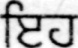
ਇਹ
